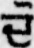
ਦੋ
